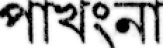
পাখংনা
